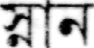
স্নান
